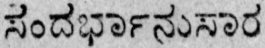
ಸಂದರ್ಭಾನುಸಾರ
